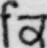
ਕਿ
